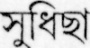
সুধিছা
